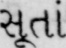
સૂતાં
